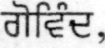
ਗੋਵਿੰਦ,
